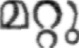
മറ്റു
